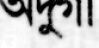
অদুগা
